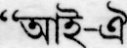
"আই-ঐ
